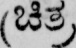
(ಚಿತ್ರ
